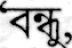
'বন্ধু,
